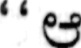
"ಆ
